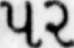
પર
